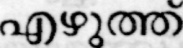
എഴുത്ത്
